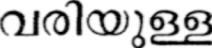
വരിയുള്ള
